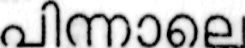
പിന്നാലെ
